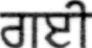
ਗਈ
